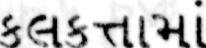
કલકત્તામાં
